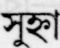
সুহ্না
